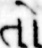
તો
